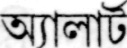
আলার্ট
